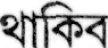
থাকিব
